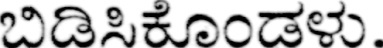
ಬಿಡಿಸಿಕೊಂಡಳು.
